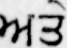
ਅਤੇ
